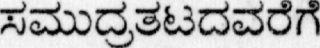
ಸಮುದ್ರತಟದವರೆಗೆ
